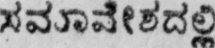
ಸಮಾವೇಶದಲ್ಲಿ
